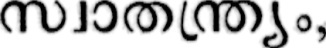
സ്വാതന്ത്ര്യം,
